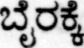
ಬೈರಕ್ಕೆ
